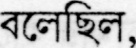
বলেছিল,
